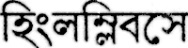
হিংলম্লিবসে
